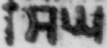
ਸਿੰਘ
